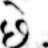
છે.
